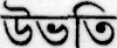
উভতি
